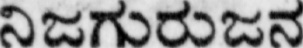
ನಿಜಗುರುಜನ
